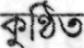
কুণ্ঠিত
